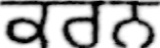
ਕਰਨ
